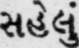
સહેલું
